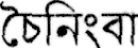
চৈনিংবা
